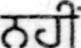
ਨਹੀਂ
